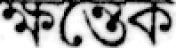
ক্ষন্তেক
